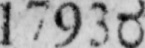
1793ರ
